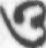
ও
